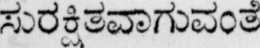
ಸುರಕ್ಷಿತವಾಗುವಂತೆ
